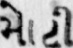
મોટી
